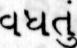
વધતું
